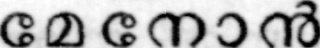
മേനോന്‍
